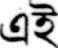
এই
